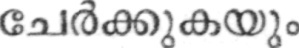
ചേര്‍ക്കുകയും
